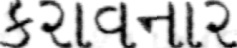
કરાવનાર
